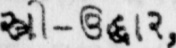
સ્ત્રી-ઉદ્ધાર,
